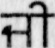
ਜੀ
